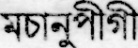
মচানুপীগী
